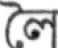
লৈ
